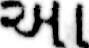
આ
